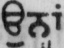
ਉਨ੍ਹਾਂ
